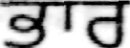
ਭਾਰ
